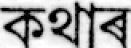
কথাৰ
